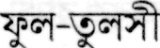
ফুল-তুলসী
